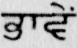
ਭਾਵੇਂ
